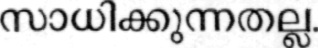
സാധിക്കുന്നതല്ല.
